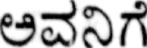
ಅವನಿಗೆ
